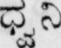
ಧ್ವನಿ
